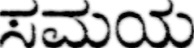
ಸಮಯ
